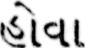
હોવા
